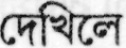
দেখিলে
